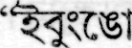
“ইবুংঙো
